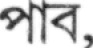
পাব,
